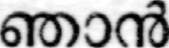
ഞാന്‍
